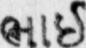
ભાઈ
